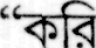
“করি
